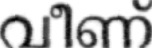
വീണ്
